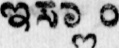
ಇಸ್ಲಾಂ
